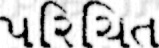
પરિચિત
